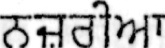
ਨਜ਼ਰੀਆ
